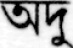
অদু
